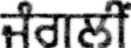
ਜੰਗਲੀਂ
